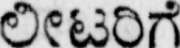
ಲೀಟರಿಗೆ
